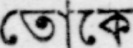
তোকে
